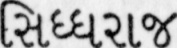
સિધ્ધરાજ
